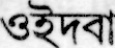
ওইদবা
